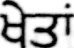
ਖੇਤਾਂ
